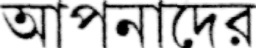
আপনাদের
